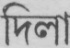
দিলা
